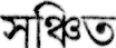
সঞ্চিত
